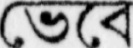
ভেবে
